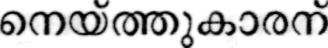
നെയ്ത്തുകാരന്
